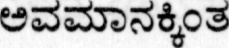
ಅವಮಾನಕ್ಕಿಂತ
